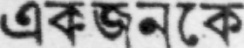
একজনকে
